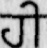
ਹੀ
